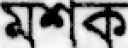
মশক
